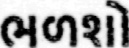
ભળશો
